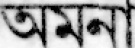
অমনা
